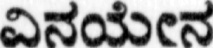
ವಿನಯೇನ
